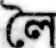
লৈ
